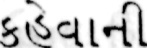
કહેવાની
